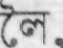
লৈ,
